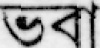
ভবা
